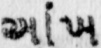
આંખ
